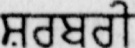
ਸ਼ਰਬਰੀ
